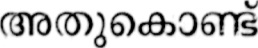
അതുകൊണ്ട്
